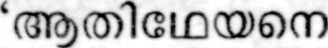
‘ആതിഥേയനെ
